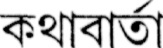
কথাবার্তা
